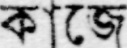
কাজে
